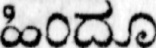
ಹಿಂದೂ
